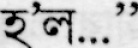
হ'ল..."
